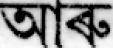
আৰু
